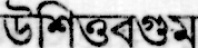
উশিত্তবগুম
